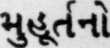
મુહૂર્તનો
